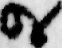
જ
